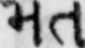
મત
